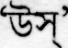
'উস্'
